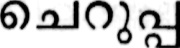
ചെറുപ്പ
